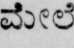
ಮೇಲೆ
